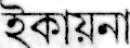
ইকায়না
